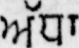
ਅੱਧਾ
